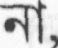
না,
